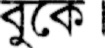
বুকে।
